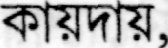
কায়দায়,
